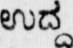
ಉದ್ದ
